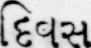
દિવસ
